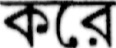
করে
